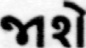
જાશે
